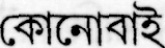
কোনোবাই
